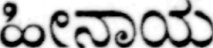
ಹೀನಾಯ
